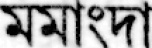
মমাংদা
